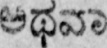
ಅಥವಾ
